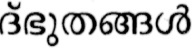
ദ്ഭുതങ്ങള്‍'
